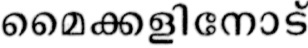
മൈക്കളിനോട്
